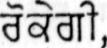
ਰੋਕੇਗੀ,
